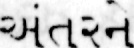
અંતરને
